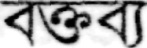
বক্তব্য
